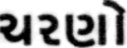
ચરણો
